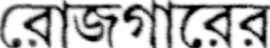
রোজগারের
